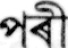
পৰী
